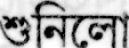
শুনিলো
